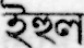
ইহুল
